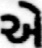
એ
